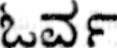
ಓರ್ವ
